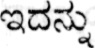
ಇದನ್ನು
